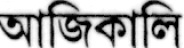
আজিকালি
